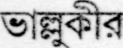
ভাল্লুকীর
